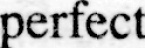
perfect
